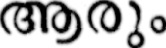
ആരും
